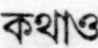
কথাও
